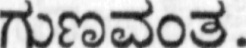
ಗುಣವಂತ.
